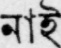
নাই
